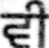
ਵੀ
